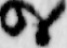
જ
